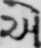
એ
